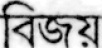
বিজয়
